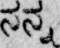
ನನ್ನ
